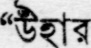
‘‘উঁহার
